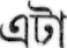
এটা
